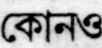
কোনও
